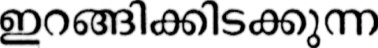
ഇറങ്ങിക്കിടക്കുന്ന
